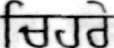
ਚਿਹਰੇ
